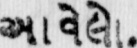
આવેલો.
